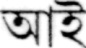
আই
